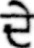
ਦੇ
